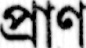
প্রাণ
